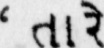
તારે
